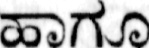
ಹಾಗೂ
